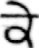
ਕੇ
